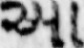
આ
